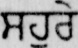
ਸਹੁਰੇ
